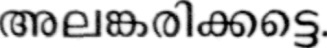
അലങ്കരിക്കട്ടെ.
